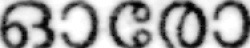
ഓരോ
